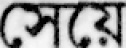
সেয়ে
